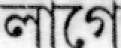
লাগে
